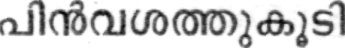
പിന്‍വശത്തുകൂടി
